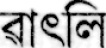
ৱাৎলি
